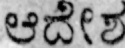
ಆದೇಶ
